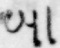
બા
